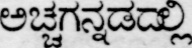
ಅಚ್ಚಗನ್ನಡದಲ್ಲಿ
